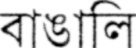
বাঙালি
